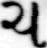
ચ
